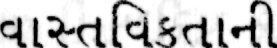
વાસ્તવિકતાની
